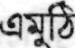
এমুঠি
